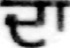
ਦਾ
